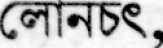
লোনচৎ,
